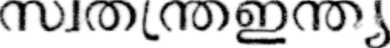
സ്വതന്ത്രഇന്ത്യ
